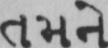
તમને
